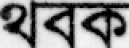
থবক
